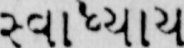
સ્વાધ્યાય
